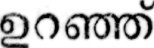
ഉറഞ്ഞ്
